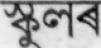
স্কুলৰ
